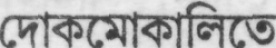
দোকমোকালিতে
